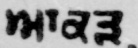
ਆਕੜ,
